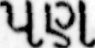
પણ
